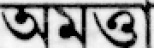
অমত্তা
